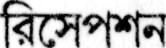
রিসেপশন
